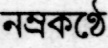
নম্রকণ্ঠে
